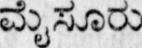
ಮೈಸೂರು
